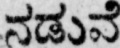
ನಡುವೆ
